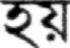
হয়
